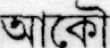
আকৌ
